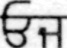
ਓਜ
